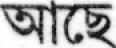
আছে
